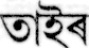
তাইৰ
